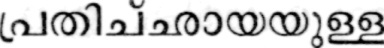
പ്രതിച്ഛായയുള്ള
